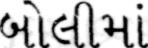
બોલીમાં
